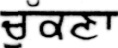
ਚੁੱਕਣਾ
